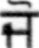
ਜੋ
